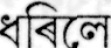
ধৰিলে
